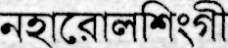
নহারোলশিংগী
